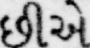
છીએ
